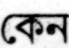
কেন
